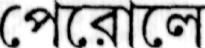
পেরোলে
